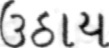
ઉઠાય
